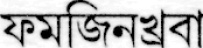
ফমজিনখ্রবা
